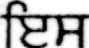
ਇਸ
